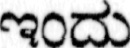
ಇಂದು
